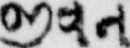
જીવન
